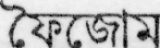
ফৈজোম
